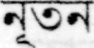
নূতন
